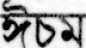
ঈচম
